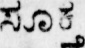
ಸೂಕ್ತ
